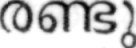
രണ്ടു
